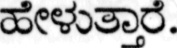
ಹೇಳುತ್ತಾರೆ.
